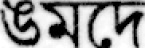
ঙমদে
